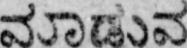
ಮಾಡುವ
